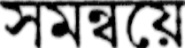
সমন্বয়ে
